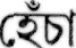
হেঁচা
